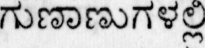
ಗುಣಾಣುಗಳಲ್ಲಿ
